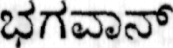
ಭಗವಾನ್
